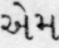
એમ
